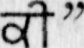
ਕੀ''
